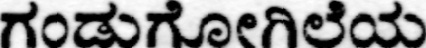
ಗಂಡುಗೋಗಿಲೆಯ
